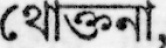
থোক্তনা,
